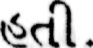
હતી.
